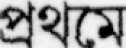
প্রথমে
